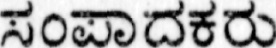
ಸಂಪಾದಕರು
